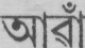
আৱাঁ
